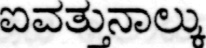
ಐವತ್ತುನಾಲ್ಕು
